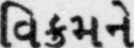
વિક્રમને
